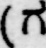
(ಗ
